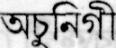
অচুনিগী
